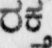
ರಕ್ತ
